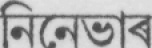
নিনেভাৰ
